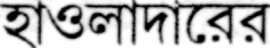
হাওলাদারের
